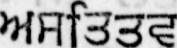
ਅਸਤਿਤਵ
